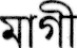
মাগী
